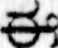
ಈ
